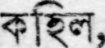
কহিল,
